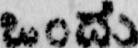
ಒಂದು
